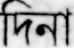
দিনা
